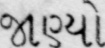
જાણ્યો
